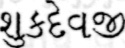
શુકદેવજી
